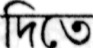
দিতে
